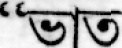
"ভাত
